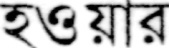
হওয়ার
